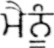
ਮੈਨੂੰ
